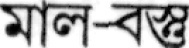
মাল-বস্তু
